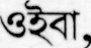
ওইবা,
